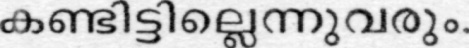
കണ്ടിട്ടില്ലെന്നുവരും.
